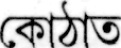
কোঠাত
